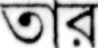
তার
